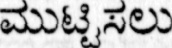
ಮುಟ್ಟಿಸಲು
